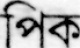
পিক
